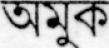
অমুক
